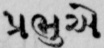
પ્રભુએ
